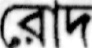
রোদ
